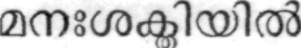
മനഃശക്തിയില്‍
